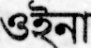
ওইনা
